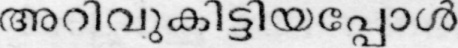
അറിവുകിട്ടിയപ്പോള്‍
